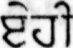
ਏਹੀ
